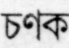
চণক
